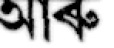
আৰু
